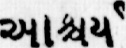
આશ્ચર્ય
